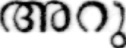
അറു
